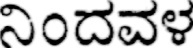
ನಿಂದವಳ
